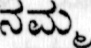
ನಮ್ಮ
